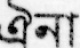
ঐনা
